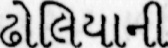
ઢોલિયાની
